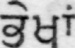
ਭੇਖਾਂ
